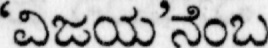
‘ವಿಜಯ'ನೆಂಬ
